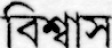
বিশ্বাস
